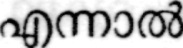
എന്നാല്‍
